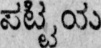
ಪಟ್ಟಿಯ
